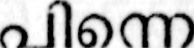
പിന്നെ
